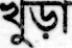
খুড়া
